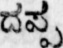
ದಪ್ಪ
